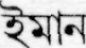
ইমান
